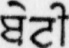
ਬੇਟੀ
